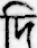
দি
